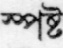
স্পষ্ট
